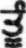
ਤੂੰ
